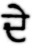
ਦੇ
